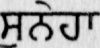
ਸੁਨੇਹਾ
